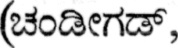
(ಚಂಡೀಗಡ್,
